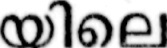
യിലെ
